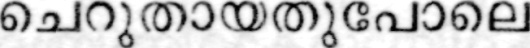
ചെറുതായതുപോലെ
